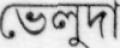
ভেলুদা
